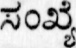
ಸಂಖ್ಯೆ
